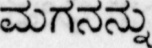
ಮಗನನ್ನು
